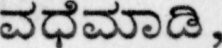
ವಧೆಮಾಡಿ,
